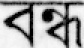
বন্ধ
